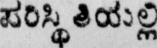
ಪರಿಸ್ಥಿತಿಯಲ್ಲಿ
